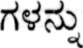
ಗಳನ್ನು
